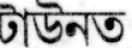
টাউনত
